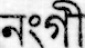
নংগী
